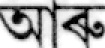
আৰু
